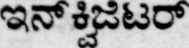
ಇನ್ಕ್ವಿಜಿಟರ್
